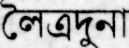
লৈত্রদুনা
